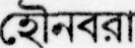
হৌনবরা
